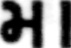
મા
